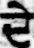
ਦੇ
